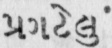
પ્રગટેલું
